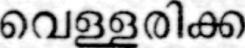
വെള്ളരിക്ക
